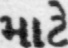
માટે
